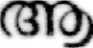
ആ
